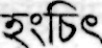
হংচিৎ
